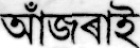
আঁজৰাই
